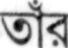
তাঁর
